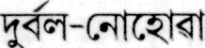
দুর্বল-নোহোৱা
